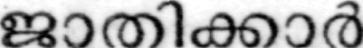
ജാതിക്കാര്‍
